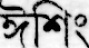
ঈশিং
